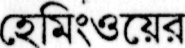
হেমিংওয়ের
